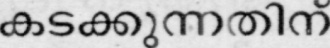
കടക്കുന്നതിന്
